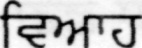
ਵਿਆਹ
